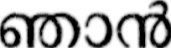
ഞാന്‍
